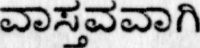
ವಾಸ್ತವವಾಗಿ
